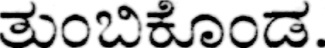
ತುಂಬಿಕೊಂಡ.
